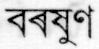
বৰষুণ
